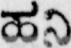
ಹನಿ
